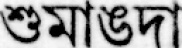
শুমাঙদা
